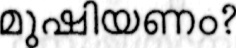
മുഷിയണം?
